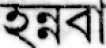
হন্নবা
